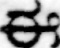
ಈ
